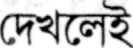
দেখলেই
